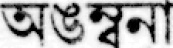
অঙম্বনা
